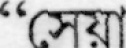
"সেয়া
